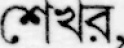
শেখর,
